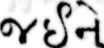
જઈને
